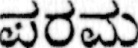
ಪರಮ
